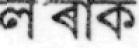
ল'ৰাক
